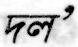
দল’
